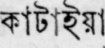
কাটাইয়া
